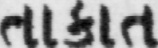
તાકાત
